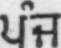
ਪੰਜ
